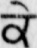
ਕੇ
